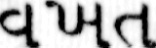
વખત
